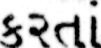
કરતાં
